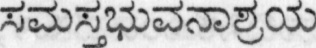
ಸಮಸ್ತಭುವನಾಶ್ರಯ
